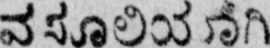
ವಸೂಲಿಯಾಗಿ
